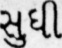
સુધી
